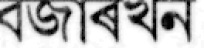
বজাৰখন
